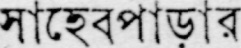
সাহেবপাড়ার
